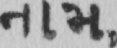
નામ,
